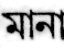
মানা
